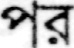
পর
